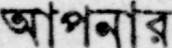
আপনার
